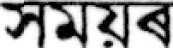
সময়ৰ
